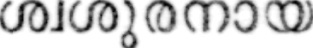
ശ്വശുരനായ
